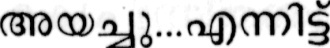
അയച്ചു...എന്നിട്ട്
